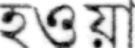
হওয়া
